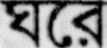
ঘরে
